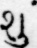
શું
